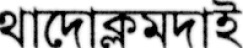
থাদোক্লমদাই
